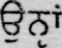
ਉਨ੍ਹਾਂ
